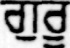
ਗੁਰੂ
